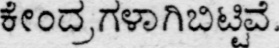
ಕೇಂದ್ರಗಳಾಗಿಬಿಟ್ಟಿವೆ.
